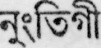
নুংতিগী
